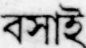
বসাই
